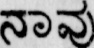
ನಾವು
